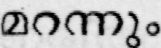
മറന്നും
